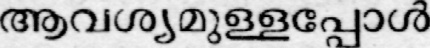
ആവശ്യമുള്ളപ്പോള്‍
